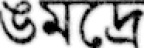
ঙমদ্রে
